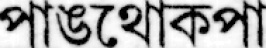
পাঙথোকপা
